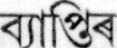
ব্যাপ্তিৰ
